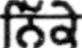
ਨਿੱਕੇ
